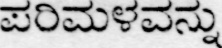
ಪರಿಮಳವನ್ನು
